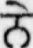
ਨੇ
